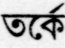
তর্কে
